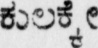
ಕುಲಕ್ಕೇ
